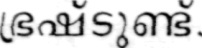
ഭ്രഷ്ടുണ്ട്.
